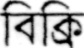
বিক্রি
